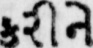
કરીને
